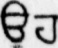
ਉਹ
